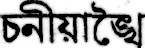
চনীয়াঙ্খৈ
